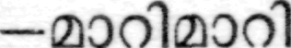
-മാറിമാറി
